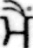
ਮੈਂ
